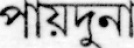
পায়দুনা
